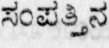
ಸಂಪತ್ತಿನ
